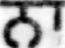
ਨਾ
